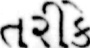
તરીકે
